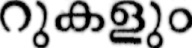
റുകളും
